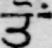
ਤੋਂ
